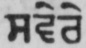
ਸਵੇਰੇ
